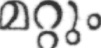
മറ്റും
